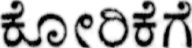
ಕೋರಿಕೆಗೆ
